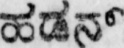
ಹಡನ್
